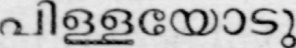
പിള്ളയോടു
